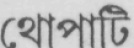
থোপাটি
